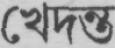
খেদন্ত
